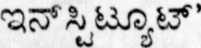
ಇನ್‌ಸ್ಟಿಟ್ಯೂಟ್’
